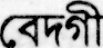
বেদগী
